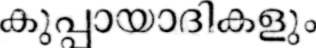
കുപ്പായാദികളും
